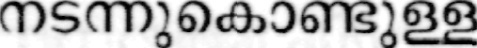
നടന്നുകൊണ്ടുള്ള
